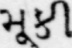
મૂકી
